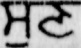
ਸੁਣ
